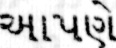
આપણે
